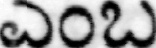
ಎಂಬ
